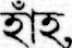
হাঁহ,
